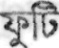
ফুটি
